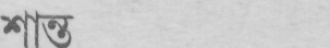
শান্ত
